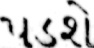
પડશે
